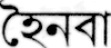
হৈনবা
